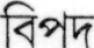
বিপদ
